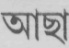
আছা
